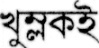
খুম্লকই
